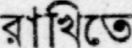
রাখিতে
